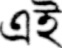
এই
